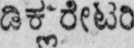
ಡಿಕ್ಲರೇಟರಿ
